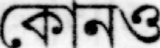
কোনও
